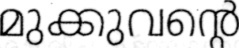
മുക്കുവന്റെ
